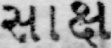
સાક્ષ
